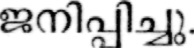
ജനിപ്പിച്ചു.
